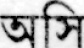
অসি
